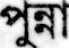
পুন্না
